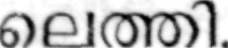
ലെത്തി.
